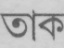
তাক
